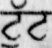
ਟੁੱਟ
